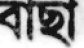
বাছা
